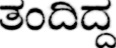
ತಂದಿದ್ದ
